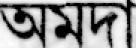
অমদা
